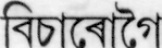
বিচাৰোগৈ
